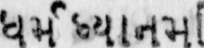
ધર્મધ્યાનમાં
